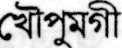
খৌপুমগী
